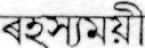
ৰহস্যময়ী
